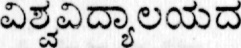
ವಿಶ್ವವಿದ್ಯಾಲಯದ
